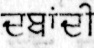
ਦਬਾਂਦੀ
